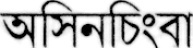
অসিনচিংবা
